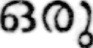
ഒരു
